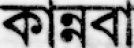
কান্নবা
